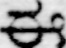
ಈ
